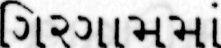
ગિરગામમાં
